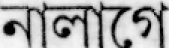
নালাগে
